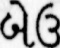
બેઉ
